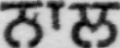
ਨਾਲ
